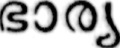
ഭാര്യ
